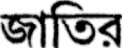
জাতির
